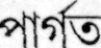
পার্গত
